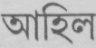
আহিল
